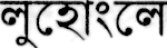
লুহোংলে
